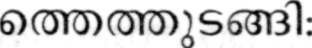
ത്തെത്തുടങ്ങി:
